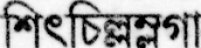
শিৎচিল্লম্লগা
